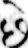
છે
